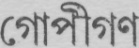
গোপীগণ
